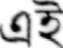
এই
